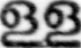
ള്ള
